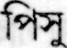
পিসু
